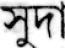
সুদা
